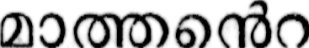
മാത്തന്റെ
